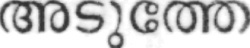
അടുത്തേ
